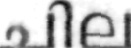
ചില
